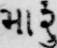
મારું
